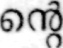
ന്റെ
